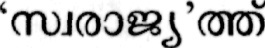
‘സ്വരാജ്യ’ത്ത്
